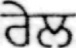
ਰੇਲ
